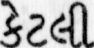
કેટલી
